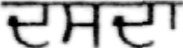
ਦਸਦਾ
